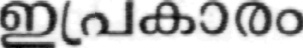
ഇപ്രകാരം
